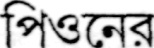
পিওনের
